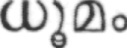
ധൂമം
